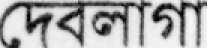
দেবলাগা
